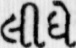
લીધે
